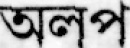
অলপ
